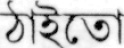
ঠাইতো
